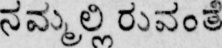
ನಮ್ಮಲ್ಲಿರುವಂತೆ
